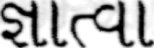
જ્ઞાત્વા
